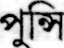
পুন্সি
